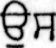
ਉਸ
